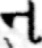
ન
